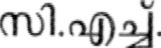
സി.എച്ച്.
